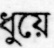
ধুয়ে
